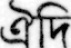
ঐদি
